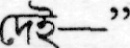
দেই-"
